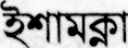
ইশামক্না
